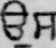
ਉਸ
